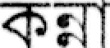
কন্না
